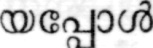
യപ്പോള്‍
